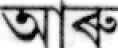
আৰু
